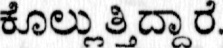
ಕೊಲ್ಲುತ್ತಿದ್ದಾರೆ.
